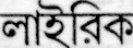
লাইরিক
